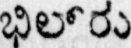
ಭಿಲ್‌ರು
